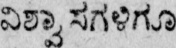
ವಿಶ್ವಾಸಗಳಿಗೂ
